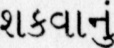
શકવાનું
